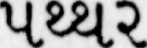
પથ્થર
